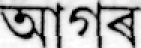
আগৰ
